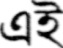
এই
